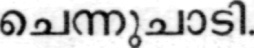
ചെന്നുചാടി.
